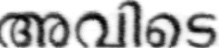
അവിടെ
